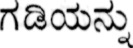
ಗಡಿಯನ್ನು
